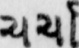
ચર્ચા
